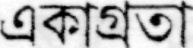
একাগ্রতা
